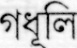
গধূলি
